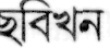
ছবিখন
